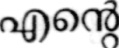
എന്റെ
